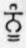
ਨੂੰ
